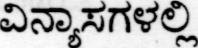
ವಿನ್ಯಾಸಗಳಲ್ಲಿ
